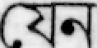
যেন
